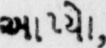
આપ્યો,
